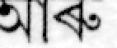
আৰু
